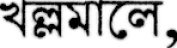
খল্লমালে,
